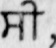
ਸੀ,
